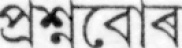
প্রশ্নবোৰ
